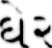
ઘેર
